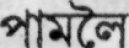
পামলৈ
